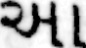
આ
